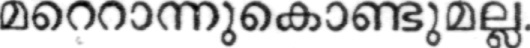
മറേറാന്നുകൊണ്ടുമല്ല.
